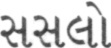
સસલો
